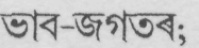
ভাব-জগতৰ;
